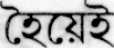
হৈয়েই
